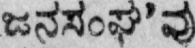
ಜನಸಂಘವು
